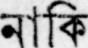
নাকি
